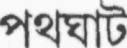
পথঘাট
